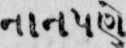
નાનપણે
